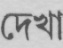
দেখা
